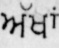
ਅੱਖਾਂ
